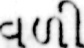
?વળી
